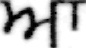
ਆ
